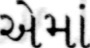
એમાં
